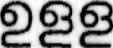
ഉള്ള
